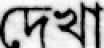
দেখা
